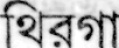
থিরগা
